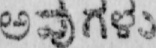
ಅವುಗಳು
